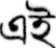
এই
